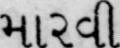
મારવી
